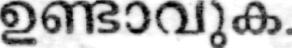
ഉണ്ടാവുക.
